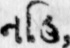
નહી.
